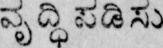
ವೃದ್ಧಿಪಡಿಸು
